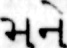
મને
